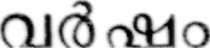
വര്‍ഷം
